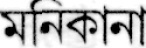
মনিকানা
